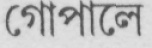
গোপালে
